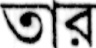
তার
